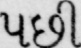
પછી
